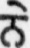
ਨੇ
